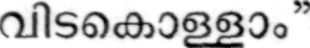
വിടകൊള്ളാം”
